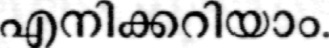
എനിക്കറിയാം.
